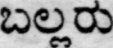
ಬಲ್ಲರು
